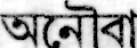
অনৌবা
